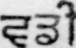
ਵਡੀ
